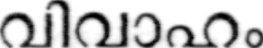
വിവാഹം
